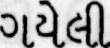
ગયેલી
